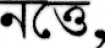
নত্তে,
